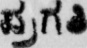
ಪ್ರಗತಿ
